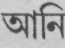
আনি
